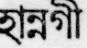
হান্নগী
